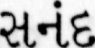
સનંદ
